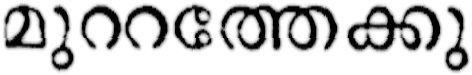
മുററത്തേക്കു
